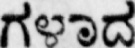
ಗಳಾದ
